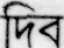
দিব
